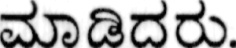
ಮಾಡಿದರು.
